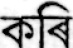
কৰি
